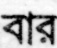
বার
